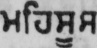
ਮਹਿਸੂਸ
